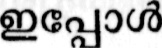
ഇപ്പോള്‍
